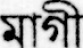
মাগী
